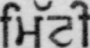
ਮਿੱਟੀ
